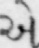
એ
